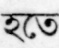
হতে
